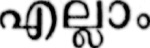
എല്ലാം
